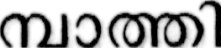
മ്പാത്തി
